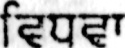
ਵਿਧਵਾ
